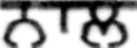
ਨਾਲ
